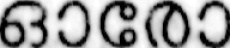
ഓരോ
